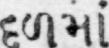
દળમાં
